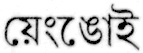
য়েংঙোই
